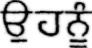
ਉਹਨੂੰ
